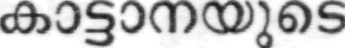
കാട്ടാനയുടെ
